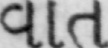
વાત
